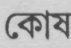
কোষ
